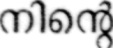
നിന്റെ
